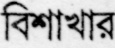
বিশাখার
